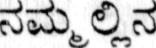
ನಮ್ಮಲ್ಲಿನ
